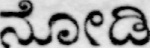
ನೋಡಿ
